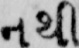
નથી
